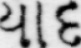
યાદ
